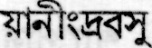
য়ানীংদ্রবসু
